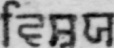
ਵਿਸ਼ਯ
